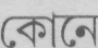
কোনে
